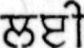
ਲਈ
